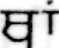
ਥਾਂ
